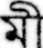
মী
